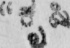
“ಕೃಷಿ
